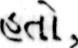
હતો,
